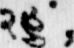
રહું,
